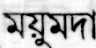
ময়ুমদা
